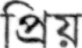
প্রিয়
